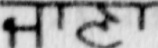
ਜਾਣਾ
